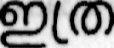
ഇത്ര
